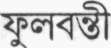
ফুলবন্তী
